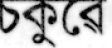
চকুৱে
